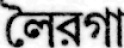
লৈরগা
